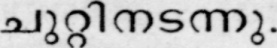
ചുറ്റിനടന്നു.
